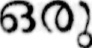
ഒരു
